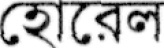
হোরেল
